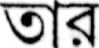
তার
